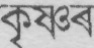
কৃষ্ণৰ
